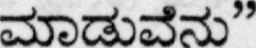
ಮಾಡುವೆನು”
